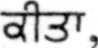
ਕੀਤਾ,
